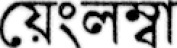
য়েংলম্বা
